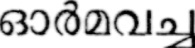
ഓര്‍മവച്ച
